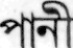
পানী
